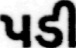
પડી
